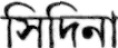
সিদিনা
